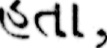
હતા,
